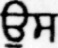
ਉਸ
